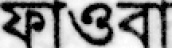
ফাওবা
